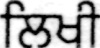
ਲਿਖੀ
